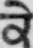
ਕੇ
